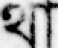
থা
